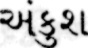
અંકુશ
